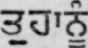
ਤੁਹਾਨੂੰ
